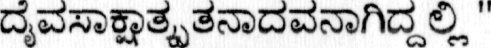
ದೈವಸಾಕ್ಷಾತ್ಕೃತನಾದವನಾಗಿದ್ದಲ್ಲಿ
